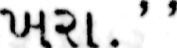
ખરા."
